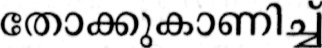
തോക്കുകാണിച്ച്
